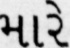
મારે
